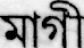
মাগী
